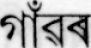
গাঁৱৰ
